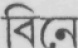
বিনে
